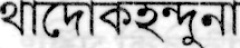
থাদোকহন্দুনা
